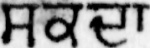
ਸਕਦਾ
